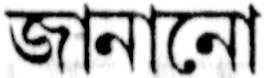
জানানো
